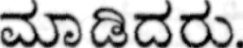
ಮಾಡಿದರು.
